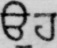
ਉਹ
